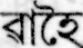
ৱাহৈ
